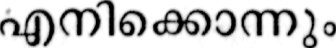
എനിക്കൊന്നും
